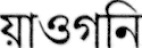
য়াওগনি
